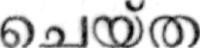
ചെയ്ത
